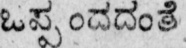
ಒಪ್ಪಂದದಂತೆ
